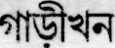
গাড়ীখন
